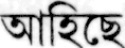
আহিছে
